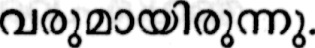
വരുമായിരുന്നു.
